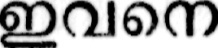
ഇവനെ
